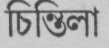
চিন্তিলা
